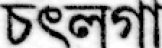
চৎলগা
